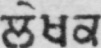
ਲੇਖਕ
